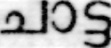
ചാട്ട
